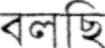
বলছি
